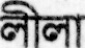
লীলা
